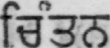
ਚਿੰਤਨ
